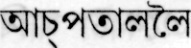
আচ্‌পতাললৈ
